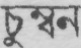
চুম্বন
